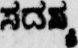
ಸದಸ್ಯ
